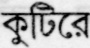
কুটিরে
